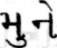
મુને
